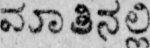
ಮಾತಿನಲ್ಲಿ
